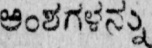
ಅಂಶಗಳನ್ನು
